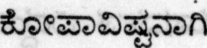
ಕೋಪಾವಿಷ್ಟನಾಗಿ
